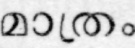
മാത്രം
